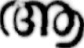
ആ
